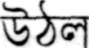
উঠল
